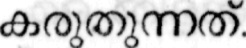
കരുതുന്നത്.
